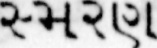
સ્મરણ
